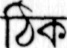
ঠিক
